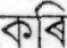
কৰি
